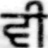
ਵੀ
